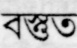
বস্তুত
